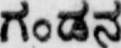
ಗಂಡನ
